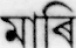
মাৰি
